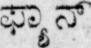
ಫ್ಯಾನ್
